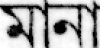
মানা
